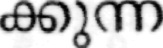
ക്കുന്ന
